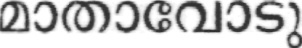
മാതാവോടു
